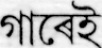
গাৰেই
